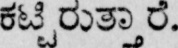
ಕಟ್ಟಿರುತ್ತಾರೆ.
